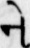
ને
